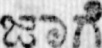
ಜಾಗೆ
